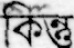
কিন্তু
